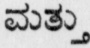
ಮತ್ತು
